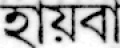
হায়বা
